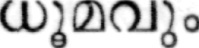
ധൂമവും
